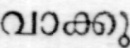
വാക്കു
